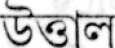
উত্তাল
